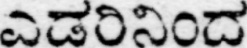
ಎಡರಿನಿಂದ
